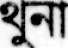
থুনা
